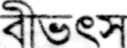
বীভৎস
